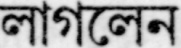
লাগলেন
